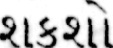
શકશો
